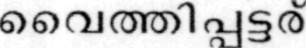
വൈത്തിപ്പട്ടര്
